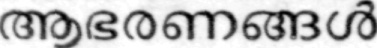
ആഭരണങ്ങള്‍
